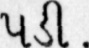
પડી.
